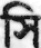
সি
